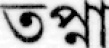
তপ্না
